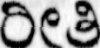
ರೀತಿ
